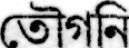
তৌগনি
